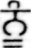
ਨੂੰ
